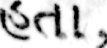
હતા,
